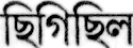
ছিগিছিল
